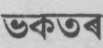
ভকতৰ
